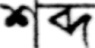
শব্দ
